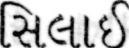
સિલાઈ
